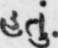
હતું.
